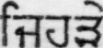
ਜਿਹੜੇ
